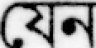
যেন
